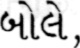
બોલે,
